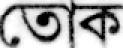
তোক
